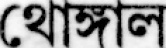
থোঙ্গাল
